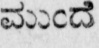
ಮುಂದೆ
